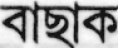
বাছাক
